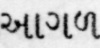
આગળ
